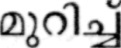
മുറിച്ച്
